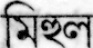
মিহুল
